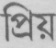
প্ৰিয়
